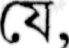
যে,
